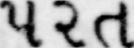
પરત
